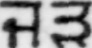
ਜੜ
